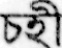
চহী
